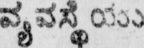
ವ್ಯವಸ್ಥೆಯು
